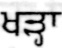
ਖੜ੍ਹਾ
